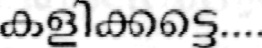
കളിക്കട്ടെ....
